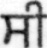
ਸੀ
